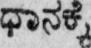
ಧಾನಕ್ಕೆ
